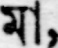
মা,
